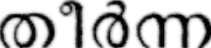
തീര്‍ന്ന
